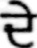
ਦੇ
